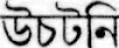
উচটনি
